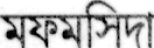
মফমসিদা
